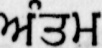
ਅੰਤਮ
